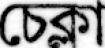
চেক্লা
